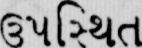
ઉપસ્થિત
